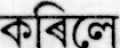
কৰিলে
